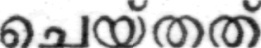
ചെയ്തത്
